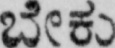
ಬೇಕು
